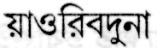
য়াওরিবদুনা
